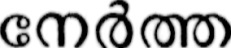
നേര്‍ത്ത
